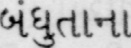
બંધુતાના
